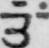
ਤੋਂ
